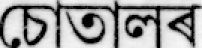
চোতালৰ
